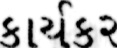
કાર્યકર
